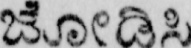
ಜೋಡಿಸಿ
